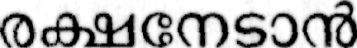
രക്ഷനേടാന്‍
